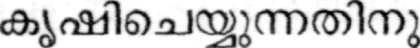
കൃഷിചെയ്യുന്നതിനു
